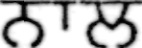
ਨਾਲ
